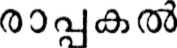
രാപ്പകല്‍
